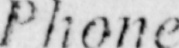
Phone
